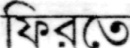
ফিরতে
